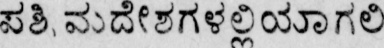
ಪಶ್ಚಿಮದೇಶಗಳಲ್ಲಿಯಾಗಲಿ
